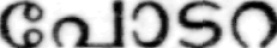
പോടറ
